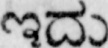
ಇದು
